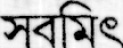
সবমিৎ
